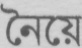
নৈয়ে
